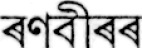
ৰণবীৰৰ
